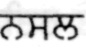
ਨਸਲ
